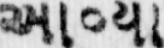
આવ્યા
